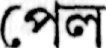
পেল
